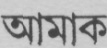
আমাক
